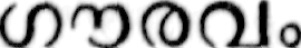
ഗൌരവം
